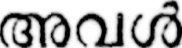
അവള്‍
